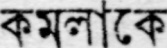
কমলাকে
